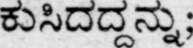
ಕುಸಿದದ್ದನ್ನು;
